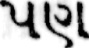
પણ
